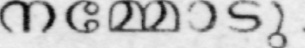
നമ്മോടു
